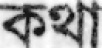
কথা
